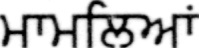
ਮਾਮਲਿਆਂ
